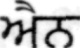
ਐਨ
